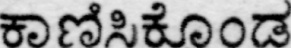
ಕಾಣಿಸಿಕೊಂಡ
